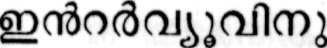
ഇന്റര്‍വ്യൂവിനു
